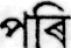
পৰি
